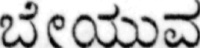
ಬೇಯುವ
